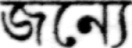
জন্যে
